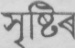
সৃষ্টিৰ
